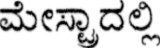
ಮೇಸ್ಟ್ರಾದಲ್ಲಿ
